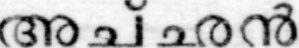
അച്ഛന്‍
